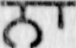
ਨਾ
